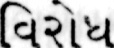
વિરોધ
